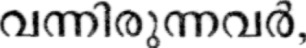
വന്നിരുന്നവര്‍,
